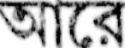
আরে
